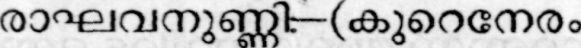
രാഘവനുണ്ണി:-(കുറെനേരം
